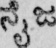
ನೈಜ
